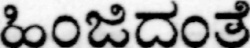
ಹಿಂಜಿದಂತೆ
